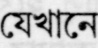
যেখানে
